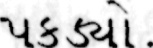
પક્ડયો.
